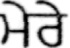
ਮੇਰੇ
